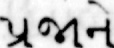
પ્રજાને
